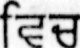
ਵਿਚ
